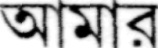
আমার
